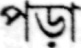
পড়া
